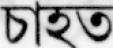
চাহত
